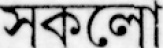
সকলো
